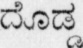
ದೊಡ್ಡ
